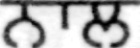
ਨਾਲ
